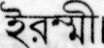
ইরম্মী।
